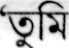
'তুমি
